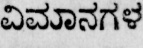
ವಿಮಾನಗಳ
